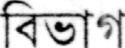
বিভাগ
